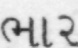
ભાર
